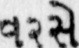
વરસે
